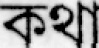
কথা
